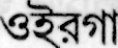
ওইরগা
